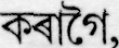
কৰাগৈ,
